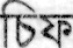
চিফ
